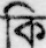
কি
